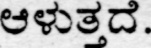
ಆಳುತ್ತದೆ.
